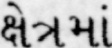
ક્ષેત્રમાં
